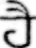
ਹੈ
